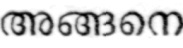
അങ്ങനെ
